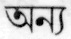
অন্য
